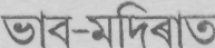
ভাব-মদিৰাত
